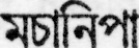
মচানিপা
